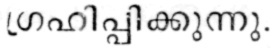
ഗ്രഹിപ്പിക്കുന്നു.
